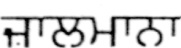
ਜ਼ਾਲਮਾਨਾ
